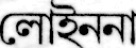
লোইননা
